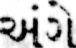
અંગે
